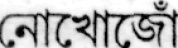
নোখোজোঁ
